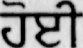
ਹੋਈ
